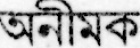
অনীমক
